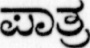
ಪಾತ್ರ
